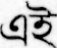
এই
